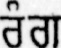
ਰੰਗ
